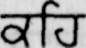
ਕਹਿ
